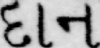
દાન
